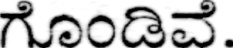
ಗೊಂಡಿವೆ.
